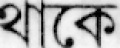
থাকে
